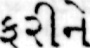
ફરીને
